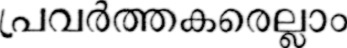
പ്രവര്‍ത്തകരെല്ലാം
